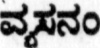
ವ್ಯಸನ೦
